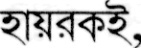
হায়রকই,
